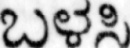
ಬಳಸಿ
